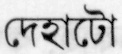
দেহাটো
